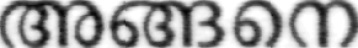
അങ്ങനെ
